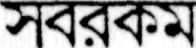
সবরকম
